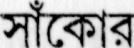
সাঁকোর
